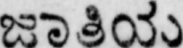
ಜಾತಿಯ
